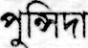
পুন্সিদা
